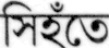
সিহঁতে
